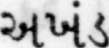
અખંડ
